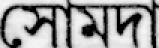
সোমদা
